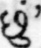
છું'
